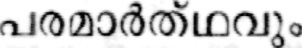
പരമാര്‍ത്ഥവും
